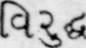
વિરુદ્ધ
